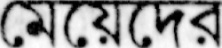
মেয়েদের
